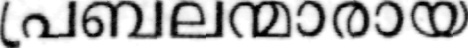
പ്രബലന്മാരായ
